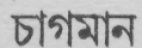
চাগমান
